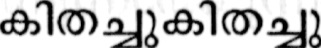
കിതച്ചുകിതച്ചു
